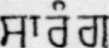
ਸਾਰੰਗ
